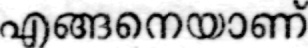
എങ്ങനെയാണ്
